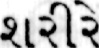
શરીરે
